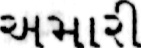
અમારી
